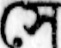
সে
